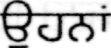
ਉਹਨਾਂ
